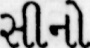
સીનો
